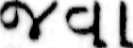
જવા
